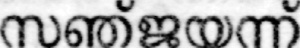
സഞ്ജയന്ന്
